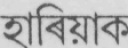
হাৰিয়াক
